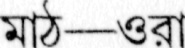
মাঠ-ওরা
